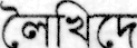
লৈখিদে
